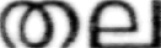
തല
